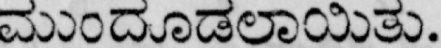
ಮುಂದೂಡಲಾಯಿತು.
